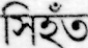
সিহঁত
